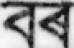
বৰ
